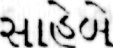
સાહેબે
